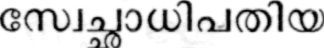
സ്വേച്ഛാധിപതിയ
